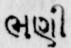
ભણી
